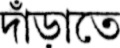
দাঁড়াতে
